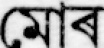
মোৰ
